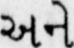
અને
